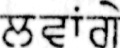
ਲਵਾਂਗੇ
